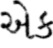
એક
